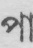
পা
